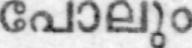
പോലും
